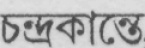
চন্দ্ৰকান্তে,
